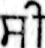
ਸੀ
